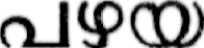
പഴയ
